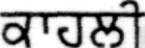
ਕਾਹਲੀ
